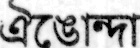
ঐঙোন্দা
